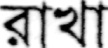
রাখা
